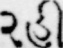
રહી
